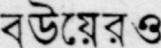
বউয়েরও
